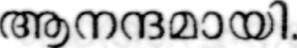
ആനന്ദമായി.
